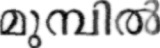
മുമ്പില്‍
